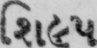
શિલ્પ
